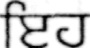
ਇਹ
